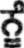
ਨੂੰ
